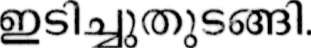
ഇടിച്ചുതുടങ്ങി.
